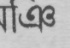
মঞি
